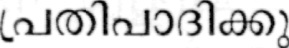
പ്രതിപാദിക്കു
